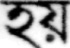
হয়
